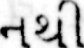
નથી
